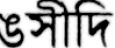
ঙসীদি
